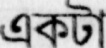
একটা
